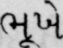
ભૂખે
